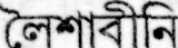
লৈশাবীনি
